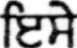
ਇਸੇ
